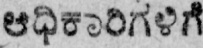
ಆಧಿಕಾರಿಗಳಿಗೆ
